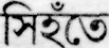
সিহঁতে
